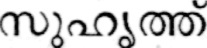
സുഹൃത്ത്
